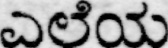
ಎಲೆಯ
